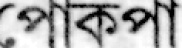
পোকপা
